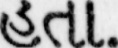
હતા.
